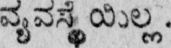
ವ್ಯವಸ್ಥೆಯಿಲ್ಲ.
